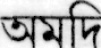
অমদি
